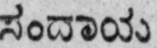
ಸಂದಾಯ
